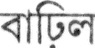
বাঢ়িল
